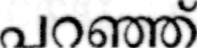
പറഞ്ഞ്
